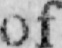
of
